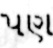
પણ
